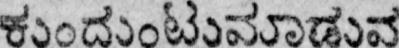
ಕುಂದುಂಟುಮಾಡುವ
